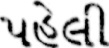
પહેલી
